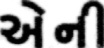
એની
